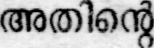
അതിന്റെ
